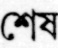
শেষ
